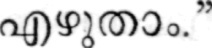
എഴുതാം."
